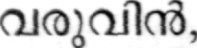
വരുവിന്‍,
